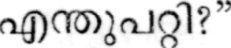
എന്തുപറ്റി?"
